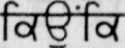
ਕਿਉਂਕਿ
